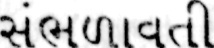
સંભળાવતી
